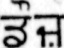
ਡੌਜ਼
